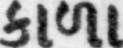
કાળા
